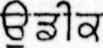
ਉਡੀਕ
